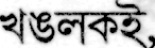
খঙলকই,
